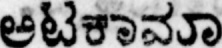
ಅಟಕಾಮಾ
